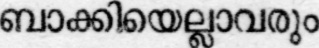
ബാക്കിയെല്ലാവരും
